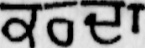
ਕਰਦਾ
